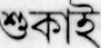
শুকাই
